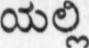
ಯಲ್ಲಿ
